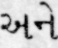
અને
